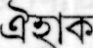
ঐহাক
